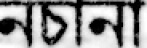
নচানা
